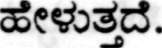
ಹೇಳುತ್ತದೆ.
